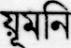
য়ূমনি
